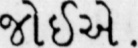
જોઈએ.
